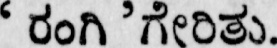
‘ರಂಗಿ’ಗೇರಿತು.
